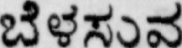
ಬೆಳೆಸುವ
